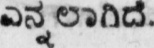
ಎನ್ನಲಾಗಿದೆ.
